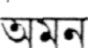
অমন
